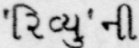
'રિવ્યુ'ની
